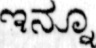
ಇನ್ನೂ
